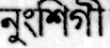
নুংশিগী
